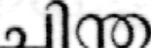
ചിന്ത
